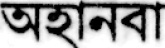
অহানবা
